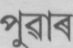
পুৱাৰ
